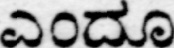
ಎಂದೂ
